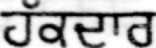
ਹੱਕਦਾਰ
